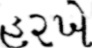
હરખે
